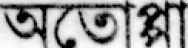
অতোপ্পা
